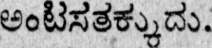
ಅಂಟಿಸತಕ್ಕುದು.
